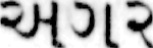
અગર
